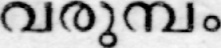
വരുമ്പം
